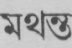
মথন্ত
